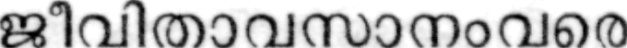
ജീവിതാവസാനംവരെ
